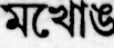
মখোঙ
